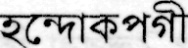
হন্দোকপগী
